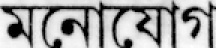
মনোযোগ
